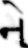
ને
